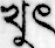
খুৎ
